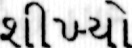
શીખ્યો
